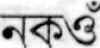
নকওঁ
